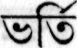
ভর্তি
